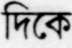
দিকে
